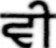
ਵੀ
